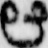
ಆ
